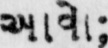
આવો;
